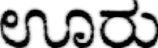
ಊರು
